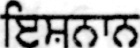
ਇਸ਼ਨਾਨ
